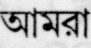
আমরা
